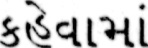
કહેવામાં
